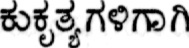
ಕುಕೃತ್ಯಗಳಿಗಾಗಿ
